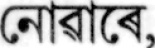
নোৱাৰে,
